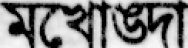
মখোঙদা
